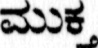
ಮುಕ್ತ
